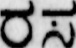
ರಸ
